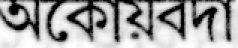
অকোয়বদা
